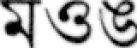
মওঙ
